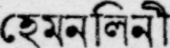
হেমনলিনী
